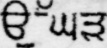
ਉੱਘੜ
